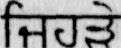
ਜਿਹੜੇ
